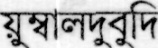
য়ুম্বালদুবুদি
